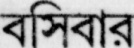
বসিবার
